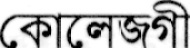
কোলেজগী
